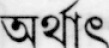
অর্থাৎ
